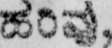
ಹರಿವು,
